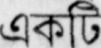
একটি
